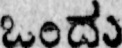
ಒಂದು
